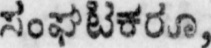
ಸಂಘಟಕರೂ,
